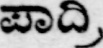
ಪಾದ್ರಿ
